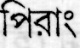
পিরাং
